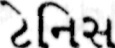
ટેનિસ
